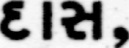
દાસ,
